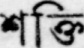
শক্তি
